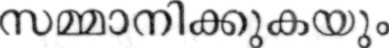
സമ്മാനിക്കുകയും
